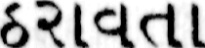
ઠરાવતા
